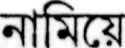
নামিয়ে
